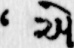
'એ
